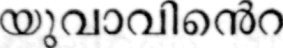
യുവാവിന്റെ
